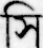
সি
